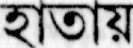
হাতায়
